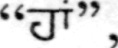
''ਹਾਂ'',
